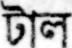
টাল
